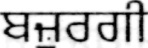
ਬਜ਼ੁਰਗੀ
